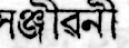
সঞ্জীৱনী
